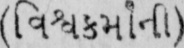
(વિશ્વકર્માની)
